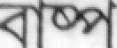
বাষ্প
